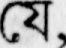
যে,
